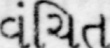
વંચિત
